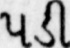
પડી
